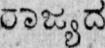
ರಾಜ್ಯದ
